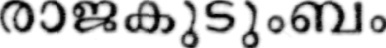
രാജകുടുംബം
